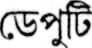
ডেপুটি
